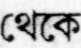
থেকে
